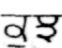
ਕੁਝ
